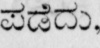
ಪಡೆದು,
